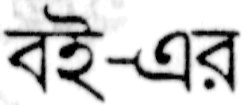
বই-এর
